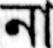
না
